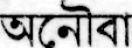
অনৌবা
